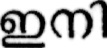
ഇനി
